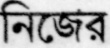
নিজের
